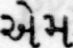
એમ
